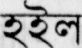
হইল
